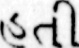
હતી
